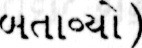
બતાવ્યો)
